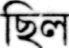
ছিল
